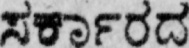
ಸರ್ಕಾರದ
